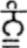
ਨੂੰ
